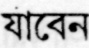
যাবেন
